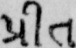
પ્રીત
